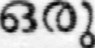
ഒരു
